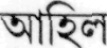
আহিল
